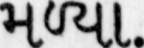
મળ્યા.
